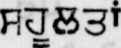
ਸਹੂਲਤਾਂ
